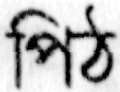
পিঠ
